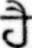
ਹੈ
